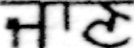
ਜਾਣ
